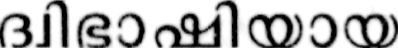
ദ്വിഭാഷിയായ
